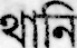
থানি
